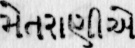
મેતરાણીએ
